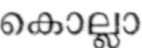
കൊല്ലാ
